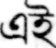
এই
